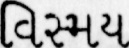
વિસ્મય
